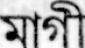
মাগী
